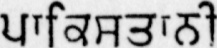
ਪਾਕਿਸਤਾਨੀ
